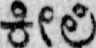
ಕೀಲಿ
